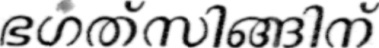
ഭഗത്സിങ്ങിന്
